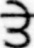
ਤੇ
